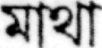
মাথা
